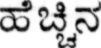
ಹೆಚ್ಚಿನ
